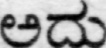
ಅದು
